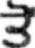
ਤੋਂ
